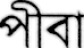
পীবা
